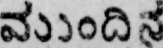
ಮುಂದಿನ
